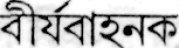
বীর্যবাহনক
